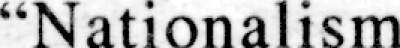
“Nationalism
